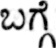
ಬಗ್ಗೆ
